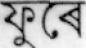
ফুৰে
